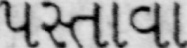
પસ્તાવા
